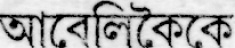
আবেলিকৈকে
